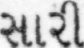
સારી
